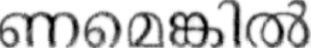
ണമെങ്കില്‍
